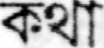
কথা
